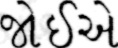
જોઈએ
